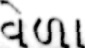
વેળા
